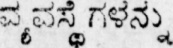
ವ್ಯವಸ್ಥೆಗಳನ್ನು
